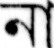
না
